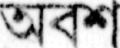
অবশ
